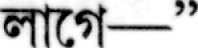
লাগে-"
